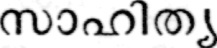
സാഹിത്യ
